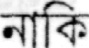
নাকি
